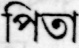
পিতা
